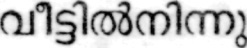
വീട്ടില്‍നിന്നു
